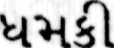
ધમકી
